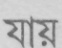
যায়
